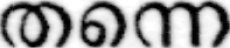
തന്നെ
